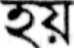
হয়
